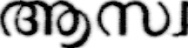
ആസ്വ
